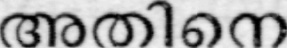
അതിനെ
